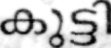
കുട്ടി
